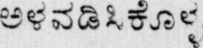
ಅಳವಡಿಸಿಕೊಳ್ಳ
